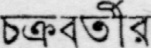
চক্রবর্তীর
